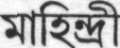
মাহিন্দ্রী
